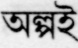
অল্পই
